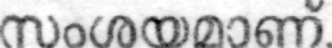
സംശയമാണ്.
